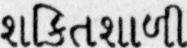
શક્તિશાળી
